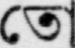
তো
